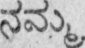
ನಮ್ಮ
